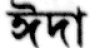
ঈদা
